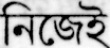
নিজেই
